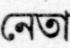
নেতা
